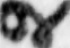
જ
